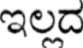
ಇಲ್ಲದ
